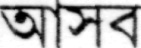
আসব
